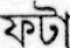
ফটা
